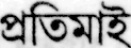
প্রতিমাই
